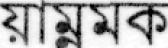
য়াম্নমক
